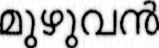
മുഴുവന്‍
